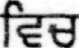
ਵਿਚ
